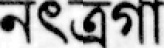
নৎত্রগা
